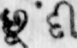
છૂંદી
